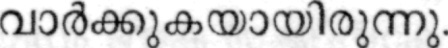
വാര്‍ക്കുകയായിരുന്നു.
